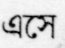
এসে
